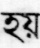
হয়
